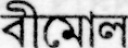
বীমোল
